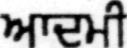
ਆਦਮੀ
